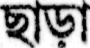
ছাড়া
